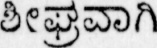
ಶೀಘ್ರವಾಗಿ
